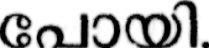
പോയി.
